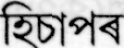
হিচাপৰ
